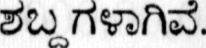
ಶಬ್ದಗಳಾಗಿವೆ.
